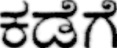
ಕಡೆಗೆ
